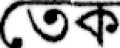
তেক
